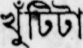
খুঁটিটা
